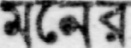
মনের
